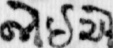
જોઈએ
